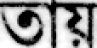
তায়
